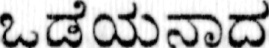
ಒಡೆಯನಾದ
